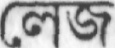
লেজ
